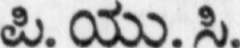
ಪಿ.ಯು.ಸಿ
